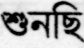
শুনছি
